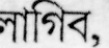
লাগিব,
